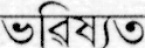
ভৱিষ্যত
